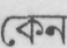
কেন
